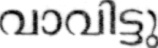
വാവിട്ടു
